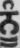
ਨੂੰ
